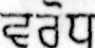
ਵਰੋਧ
